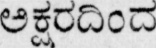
ಅಕ್ಷರದಿಂದ
